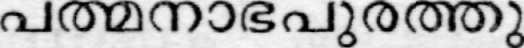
പത്മനാഭപുരത്തു
